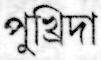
পুখ্রিদা
